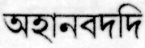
অহানবদদি
